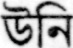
উনি
